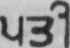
ਪਤੀ
